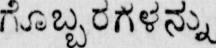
ಗೊಬ್ಬರಗಳನ್ನು
